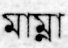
য়াম্না
